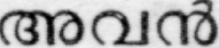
അവന്‍
